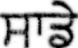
ਸਾਡੇ
